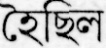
হৈছিল
